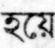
হয়ে
